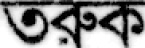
তরুক
